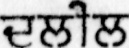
ਦਲੀਲ
